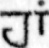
ਹਾਂ
